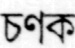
চণক
